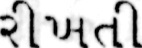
રીખતી
